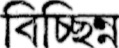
বিচ্ছিন্ন
